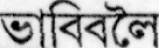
ভাবিবলৈ
